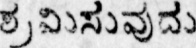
ಶ್ರಮಿಸುವುದು
